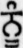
ਨੂੰ
